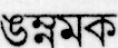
ঙম্নমক
